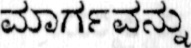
ಮಾರ್ಗವನ್ನು
